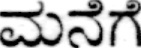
ಮನೆಗೆ
